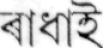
ৰাধাই
